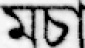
মচা
